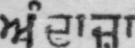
ਅੰਦਾਜ਼ਾ
